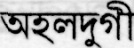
অহলদুগী
